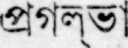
প্রগল্‌ভা
